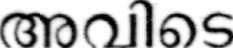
അവിടെ
